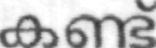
കണ്ട്
